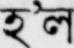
হ'ল
